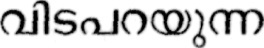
വിടപറയുന്ന
